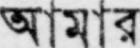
আমার
